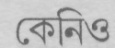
কেনিও
